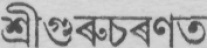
শ্ৰীগুৰুচৰণত
